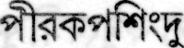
পীরকপশিংদু
